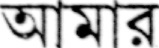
আমার
